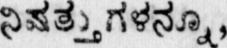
ನಿಷತ್ತುಗಳನ್ನೂ,
